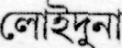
লোইদুনা
